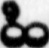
ಹಿ
